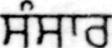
ਸੰਸਾਰ
